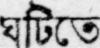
ঘটিতে
